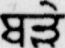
ਬੜੇ
